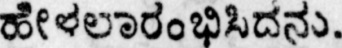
ಹೇಳಲಾರಂಭಿಸಿದನು.
